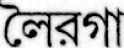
লৈরগা
